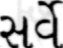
સર્વે
